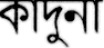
কাদুনা
